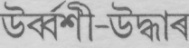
উৰ্ব্বশী-উদ্ধাৰ
